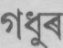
গধুৰ
